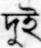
দুই
